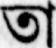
তা
